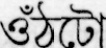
ওঁঠটো
